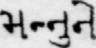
મન્નુને
